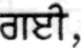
ਗਈ,
